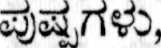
ಪುಷ್ಪಗಳು,
